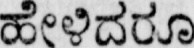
ಹೇಳಿದರೂ
